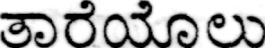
ತಾರೆಯೊಲು
